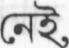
নেই,
